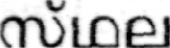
സ്ഥല
